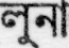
লুনা
